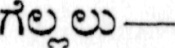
ಗೆಲ್ಲಲು-
